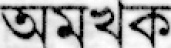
অমখক
